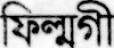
ফিল্মগী
